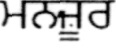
ਮਨਜ਼ੂਰ
